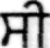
ਸੀ
